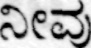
ನೀವು
